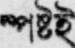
স্পষ্টই
